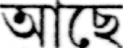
আছে
